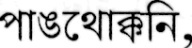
পাঙথোক্কনি,
